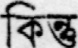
কিন্তু
